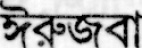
ঈরুজবা
